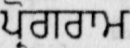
ਪ੍ਰੋਗਰਾਮ
